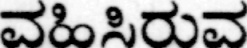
ವಹಿಸಿರುವ
